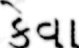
કેવા
